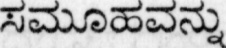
ಸಮೂಹವನ್ನು
